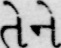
તેને
